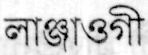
লাঞ্জাওগী
